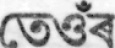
তেওঁৰ
